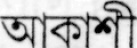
আকাশী
